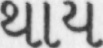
થાય
